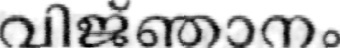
വിജ്ഞാനം
